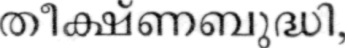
തീക്ഷ്ണബുദ്ധി,
